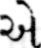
એ
